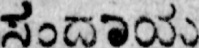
ಸಂದಾಯ
